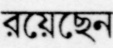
রয়েছেন
